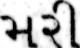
મરી
